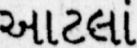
આટલાં
